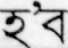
হ'ব
